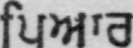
ਪਿਆਰ
